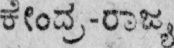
ಕೇಂದ್ರ-ರಾಜ್ಯ
